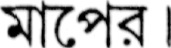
মাপের।
